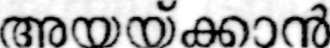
അയയ്ക്കാന്‍
